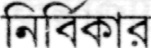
নির্বিকার
